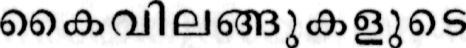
കൈവിലങ്ങുകളുടെ
